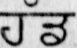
ਹੱਡ
